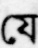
যে
